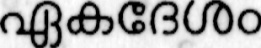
ഏകദേശം
